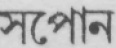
সপোন
